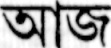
আজ
